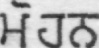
ਮੋਹਨ
